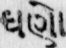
ધણો
